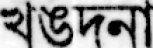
খঙদনা
